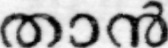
താന്‍
